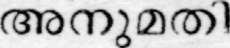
അനുമതി
